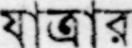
যাত্রার
